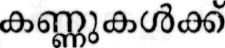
കണ്ണുകള്‍ക്ക്
